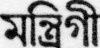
মন্ত্রিগী
